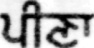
ਪੀਣਾ
